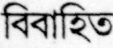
বিবাহিত
